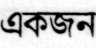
একজন
